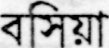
বসিয়া
